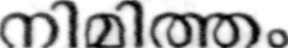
നിമിത്തം
